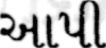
આપી
